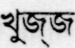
খুজ্জ
